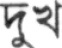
দুখ
